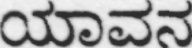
ಯಾವನ
